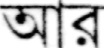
আর
